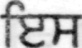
ਇਸ
